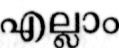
എല്ലാം
